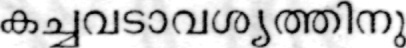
കച്ചവടാവശ്യത്തിനു
